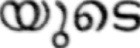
യുടെ
